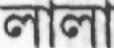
লালা
